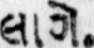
લાગે.
